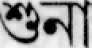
শুনা
